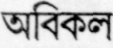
অবিকল
